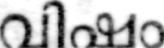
വിഷം
